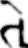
તે
